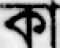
কা
